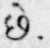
છે.
